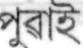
পুৱাই
